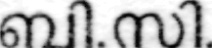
ബി.സി.
